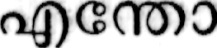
എന്തോ
